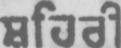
ਸ਼ਹਿਰੀ
